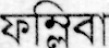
য়ূমগী
